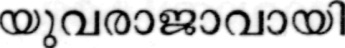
യുവരാജാവായി
